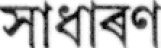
সাধাৰণ
